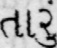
તારું
